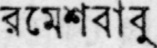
রমেশবাবু
